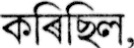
কৰিছিল,
